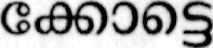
ക്കോട്ടെ
